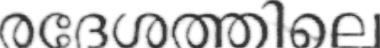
രദേശത്തിലെ
